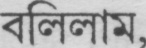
বলিলাম,
